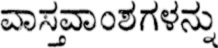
ವಾಸ್ತವಾಂಶಗಳನ್ನು
